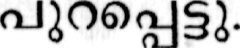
പുറപ്പെട്ടു.
